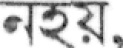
নহয়,
